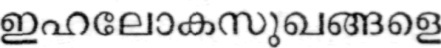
ഇഹലോകസുഖങ്ങളെ
